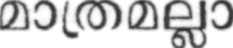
മാത്രമല്ലാ
